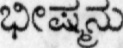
ಭೀಷ್ಮನು
